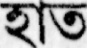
হাত
